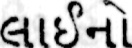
લાઈનો
